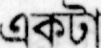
একটা
